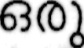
ഒരു
